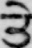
ਤੇ
